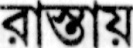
রাস্তায়
